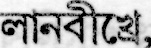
লানবীখ্রে,
